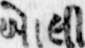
બોલી
